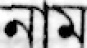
নাম
